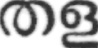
തള
